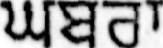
ਘਬਰਾ
